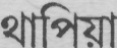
থাপিয়া
